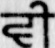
ਵੀ
